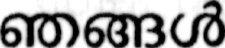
ഞങ്ങള്‍
